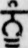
ਨੂੰ
